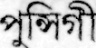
পুন্সিগী
